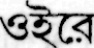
ওইরে
